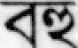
বহু
